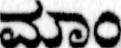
ಮಾಂ
